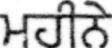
ਮਹੀਨੇ
